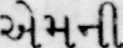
એમની
